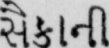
સૈકાની
